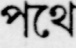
পথে
